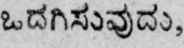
ಒದಗಿಸುವುದು,
